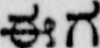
ಈಗ
